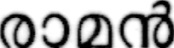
രാമന്‍
